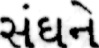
સંઘને
